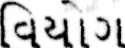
વિયોગ
